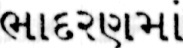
ભાદરણમાં
